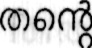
തന്റെ
